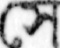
সে
